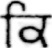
ਕਿ
